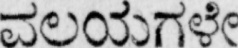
ವಲಯಗಳೇ
